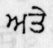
ਅਤੇ
